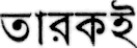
তারকই
